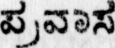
ಪ್ರವಾಸ
